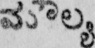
ಮೌಲ್ಯ
